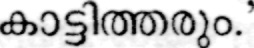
കാട്ടിത്തരും.’
